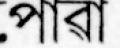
পোৱা
